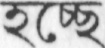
হচ্ছে
